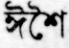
ঈশৈ
